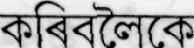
কৰিবলৈকে
